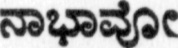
ನಾಭಾವೋ
